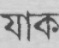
যাক
